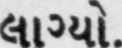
લાગ્યો.
